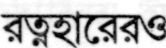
রত্নহারেরও
